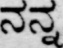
ನನ್ನ
